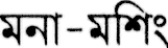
মনা-মশিং
